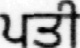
ਪਤੀ
